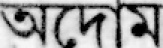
অদোম
